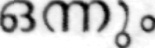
ഒന്നും
